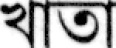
খাতা,
